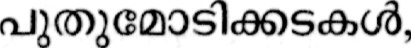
പുതുമോടിക്കടകള്‍,
